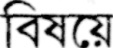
বিষয়ে
